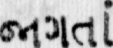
જાગતાં
